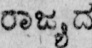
ರಾಜ್ಯದ
